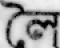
লৈ
